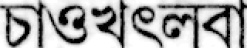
চাওখৎলবা
